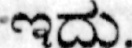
ಇದು.
